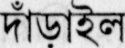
দাঁড়াইল
